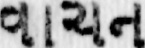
વાચન
